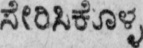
ಸೇರಿಸಿಕೊಳ್ಳ
